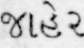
જાહેર
